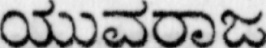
ಯುವರಾಜ
